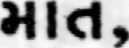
માત,
